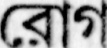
রোগ
